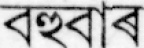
বহুবাৰ
